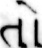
તો
